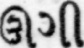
ઊગી
